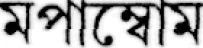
মপাম্বোম
